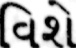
વિશે
